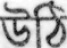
উঠি
